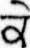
ਕੇ
